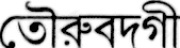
তৌরুবদগী
